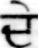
ਦੇ
